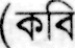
(কবি
